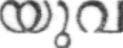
യുവ
